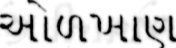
ઓળખાણ
